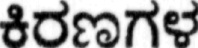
ಕಿರಣಗಳ
